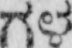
ಗಳ
